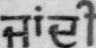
ਜਾਂਦੀ
